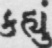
કહ્યું
